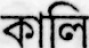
কালি
